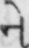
ને
